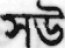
সউ
